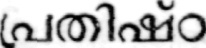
പ്രതിഷ്ഠ
